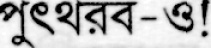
পুৎথরবা-ও!
